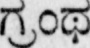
ಗ್ರಂಥ
